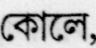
কোলে,
